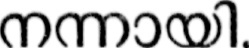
നന്നായി.
